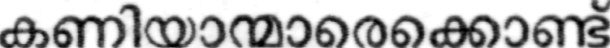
കണിയാന്മാരെക്കൊണ്ട്
